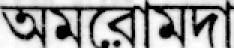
অমরোমদা
